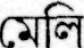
মেলি
